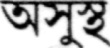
অসুস্থ
